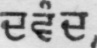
ਦਵੰਦ,
